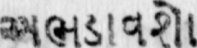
અભડાવશો
